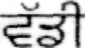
ਵੱਡੀ
